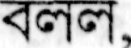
বলল,
